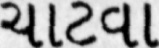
ચાટવા
